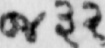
જરૂર
